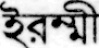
ইরম্মী
